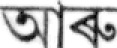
আৰু
